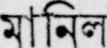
মানিল
